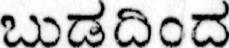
ಬುಡದಿಂದ
